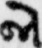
જો
